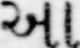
આ
